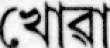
খোৱা
